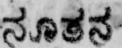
ನೂತನ
